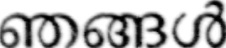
ഞങ്ങള്‍
